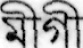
মীগী
